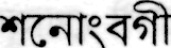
শনোংবগী
